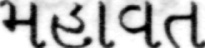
મહાવત
